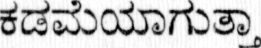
ಕಡಮೆಯಾಗುತ್ತಾ
